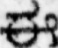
ಈ
